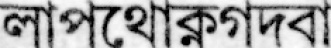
লাপথোক্নগদবা
